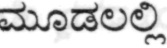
ಮೂಡಲಲ್ಲಿ
